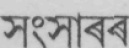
সংসাৰৰ
